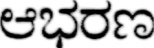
ಆಭರಣ
